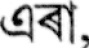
এৰা,
